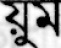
য়ুম
